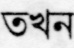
তখন
